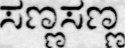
ಸಣ್ಣಸಣ್ಣ
